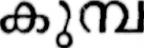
കുമ്പ
